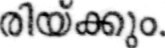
രിയ്ക്കും.
